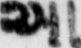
આ
